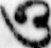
ও
